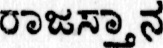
ರಾಜಸ್ತಾನ
